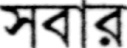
সবার
